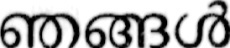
ഞങ്ങള്‍
